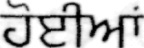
ਹੋਈਆਂ
